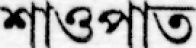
শাওপাত
